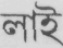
লাই
